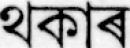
থকাৰ
